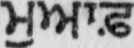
ਮੁਆਫ਼
